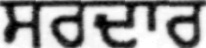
ਸਰਦਾਰ
